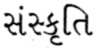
સંસ્કૃતિ
